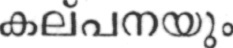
കല്പനയും
